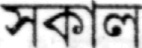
সকাল
